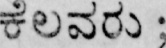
ಕೆಲವರು;
